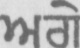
ਅਗੇ
